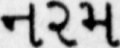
નરમ
